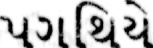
પગથિયે
